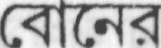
বোনের
